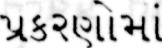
પ્રકરણોમાં
